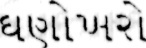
ઘણોખરો
